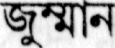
জুম্মান
